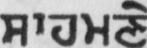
ਸਾਹਮਣੇ
